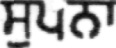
ਸੁਪਨਾ
